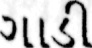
ગાડી
